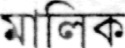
মালিক
